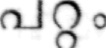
പറ്റം
